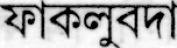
ফাকলুবদা
